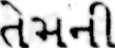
તેમની
